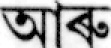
আৰু
